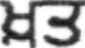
ਖ਼ਤ
